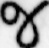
જ
